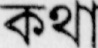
কথা
